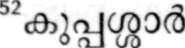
52കുപ്പശ്ശാര്‍
